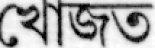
খোজত
